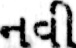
નવી
